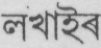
লখাইৰ
